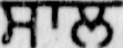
ਸਾਲ
